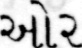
ઓર
